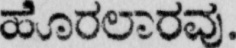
ಹೊರಲಾರವು.
